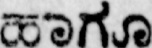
ಹಾಗೂ
